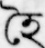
হৈ
